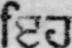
ਇਹ
